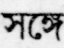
সঙ্গে
